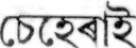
চেহেৰাই
